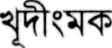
খূদীংমক
